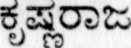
ಕೃಷ್ಣರಾಜ
